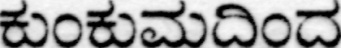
ಕುಂಕುಮದಿಂದ
